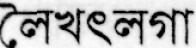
লৈখৎলগা
